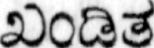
ಖಂಡಿತ
